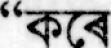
"কৰে
